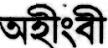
অহীংবী
